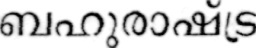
ബഹുരാഷ്ട്ര
